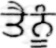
ਤੈਨੂੰ
